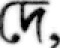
দে,
